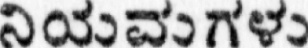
ನಿಯಮಗಳು
